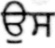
ਉਸ
